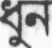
ধুন
